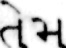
તેમ
